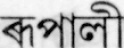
ৰূপালী
